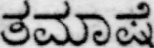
ತಮಾಷೆ
